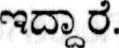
ಇದ್ದಾರೆ.
